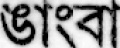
ঙাংবা
